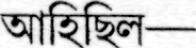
আহিছিল-
